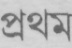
প্ৰথম
